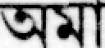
অমা
